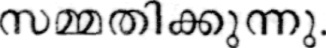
സമ്മതിക്കുന്നു.
